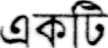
একটি
